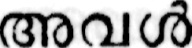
അവള്‍
